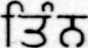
ਤਿੰਨ
